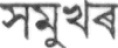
সমুখৰ
